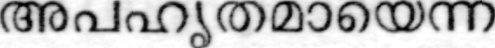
അപഹൃതമായെന്ന
